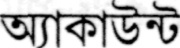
অ্যাকাউন্ট
